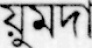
য়ুমদা
